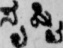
ಸೃಷ್ಟಿ
